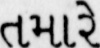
તમારે
